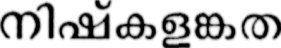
നിഷ്കളങ്കത
